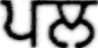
ਪਲ
